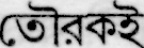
তৌরকই
